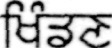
ਖਿੰਡਣ
